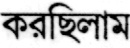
করছিলাম
